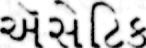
ઍસેટિક
